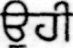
ਉਹੀ
